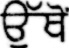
ਉੱਥੋਂ
